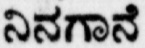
ನಿನಗಾನೆ
